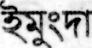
ইমুংদা
